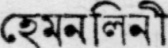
হেমনলিনী
